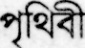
পৃথিবী
